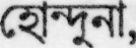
হোন্দুনা,
